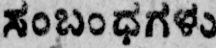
ಸಂಬಂಧಗಳು
